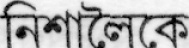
নিশালৈকে
